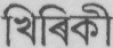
খিৰিকী
